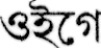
ওইগে
